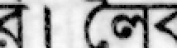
লৈব
